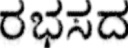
ರಭಸದ
